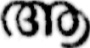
ആ
